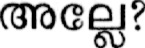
അല്ലേ?
